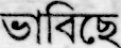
ভাবিছে
